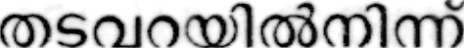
തടവറയില്‍നിന്ന്
